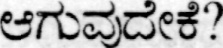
ಆಗುವುದೇಕೆ?
